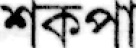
শকপা
